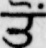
ਤੋਂ
